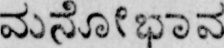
ಮನೋಭಾವ
